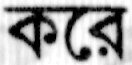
করে
